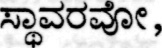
ಸ್ಥಾವರವೋ,
